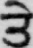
ਤੇ
